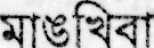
মাঙখিবা
